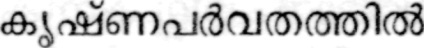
കൃഷ്ണപര്‍വതത്തില്‍
